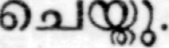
ചെയ്തു.
